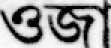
ওজা
